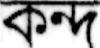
কন্দ
